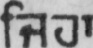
ਜਿਹਾ
